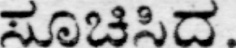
ಸೂಚಿಸಿದ.
